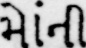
માંની
